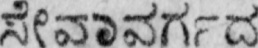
ಸೇವಾವರ್ಗದ
